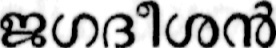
ജഗദീശന്‍
